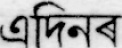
এদিনৰ
